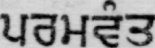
ਪਰਮਵੰਤ
